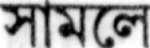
সামলে
